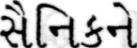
સૈનિકને
